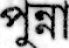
পুন্না
